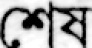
শেষ
